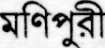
মণিপুরী
